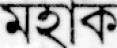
মহাক
